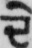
ਦੇ
